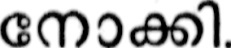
നോക്കി.
